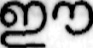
ഈ
